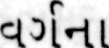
વર્ગના
